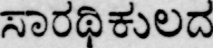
ಸಾರಥಿಕುಲದ
